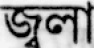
জ্বলা
